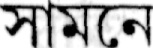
সামনে
